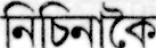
নিচিনাকৈ
